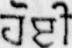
ਹੋਈ
